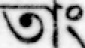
তাং
